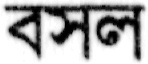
বসল
